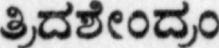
ತ್ರಿದಶೇಂದ್ರಂ
